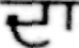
ਦਾ
